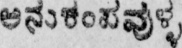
ಅನುಕಂಪವುಳ್ಳ
